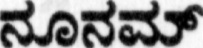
ನೂನಮ್
